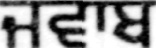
ਜਵਾਬ
